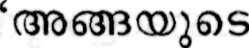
'അങ്ങയുടെ
